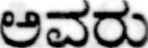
ಅವರು
